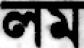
লম
